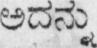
ಅದನ್ನು
